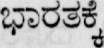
ಭಾರತಕ್ಕೆ
